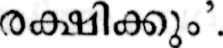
രക്ഷിക്കും'.
